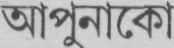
আপুনাকো
